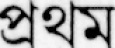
প্রথম
